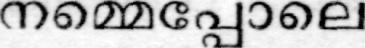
നമ്മെപ്പോലെ
